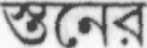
স্তনের
